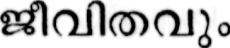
ജീവിതവും
